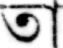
তা
